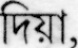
দিয়া,
